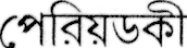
পেরিয়ডকী
